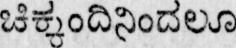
ಚಿಕ್ಕಂದಿನಿಂದಲೂ
